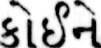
કોઈને
